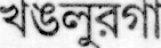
খঙলুরগা
